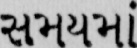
સમયમાં
